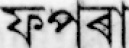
ফপৰা
